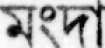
মংদা
